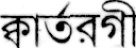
ক্বার্তরগী
